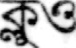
ক্লুও
